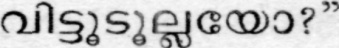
വിട്ടൂടൂല്ലയോ?"
